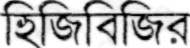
হিজিবিজির
